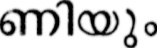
ണിയും
